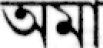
অমা
